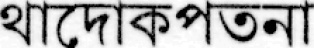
থাদোকপতনা
